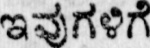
ಇವುಗಳಿಗೆ
